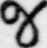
જ
